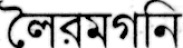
লৈরমগনি
